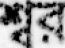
শ্বর
